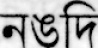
নঙদি
